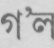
গ'ল
